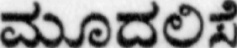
ಮೂದಲಿಸೆ
